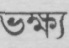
ভক্ষ্য
